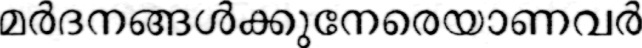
മര്‍ദനങ്ങള്‍ക്കുനേരെയാണവര്‍
